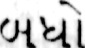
બધો
